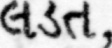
લડત
